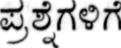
ಪ್ರಶ್ನೆಗಳಿಗೆ
